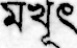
মখূৎ
